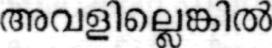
അവളില്ലെങ്കില്‍
